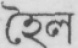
হৈল
